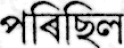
পৰিছিল
